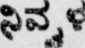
ನಿವ್ವಳ
